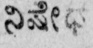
ನಿಷೇಧ
